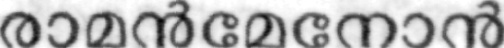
രാമന്‍മേനോന്‍
